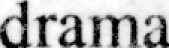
drame
